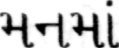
મનમાં
